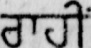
ਰਾਹੀਂ
